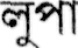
লুপা
